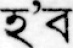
হ'ব
